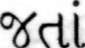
જતાં
